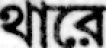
থারে
